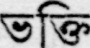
ভক্তি
